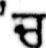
'ਚ
